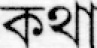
কথা
